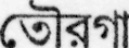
তৌরগী
